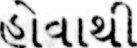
હોવાથી
